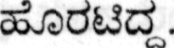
ಹೊರಟಿದ್ದ.
